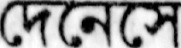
দেনেসে
